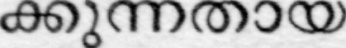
ക്കുന്നതായ
